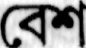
বেশ
